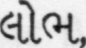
લોભ,
